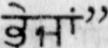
ਭੇਜਾਂ''
